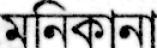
মনিকানা
